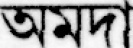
অমদা
